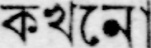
কখনো
